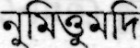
নুমিত্তুমদি
